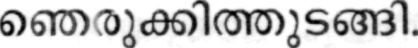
ഞെരുക്കിത്തുടങ്ങി.
